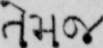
તેમજ
